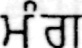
ਮੰਗ
